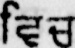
ਵਿਚ
